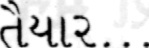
તૈયાર...
